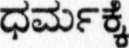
ಧರ್ಮಕ್ಕೆ
